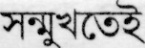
সন্মুখতেই
